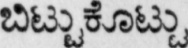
ಬಿಟ್ಟುಕೊಟ್ಟು
